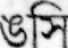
ঙসি
